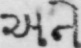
અને
